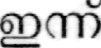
ഇന്ന്
